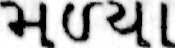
મળ્યા
